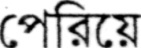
পেরিয়ে
